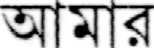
আমার
